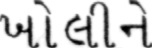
ખોલીને
